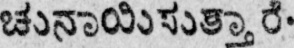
ಚುನಾಯಿಸುತ್ತಾರೆ.
